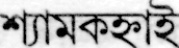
শ্যামকহ্ণাই
